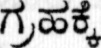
ಗ್ರಹಕ್ಕೆ
